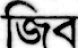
জিব
